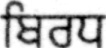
ਬਿਰਧ
